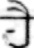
ਹੈ
